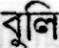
বুলি
